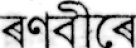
ৰণবীৰে
